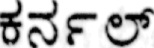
ಕರ್ನಲ್
